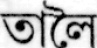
তালৈ
